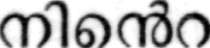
നിന്റെ
